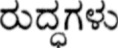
ರುದ್ಧಗಳು
